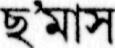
ছ’মাস
